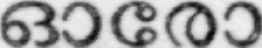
ഓരോ
